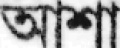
আশা
